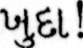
ખુદા!
